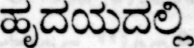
ಹೃದಯದಲ್ಲಿ
